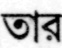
তার
